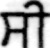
ਸੀ
